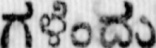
ಗಳೆಂದು
